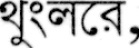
থুংলরে,
